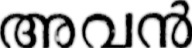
അവന്‍
